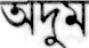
অদুম
